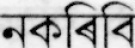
নকৰিবি
